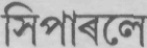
সিপাৰলে
